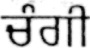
ਚੰਗੀ
